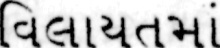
વિલાયતમાં
